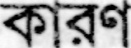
কারণ
